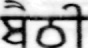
ਬੈਠੀ
